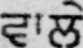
ਵਾਲੇ
